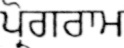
ਪ੍ਰੋਗਰਾਮ
